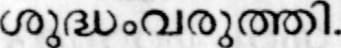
ശുദ്ധംവരുത്തി.
